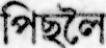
পিছলৈ
